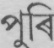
পুৰি
